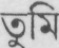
তুমি
